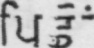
ਪਿਛੋਂ
